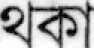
থকা
